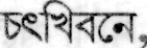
চৎখিবনে,
